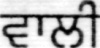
ਵਾਲੀ
